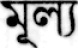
মূল্য
